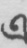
এ
